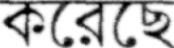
করেছে
